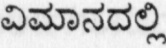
ವಿಮಾನದಲ್ಲಿ
